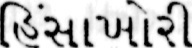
હિંસાખોરી
